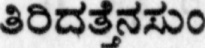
ತಿರಿದತ್ತೆನಸುಂ
